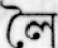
লৈ
